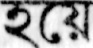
হয়ে
